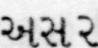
અસર
